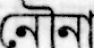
নৌনা
